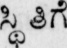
ಸ್ಥಿತಿಗೆ
